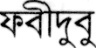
ফবীদুবু
